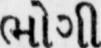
ભોગી
